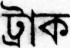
ট্রাক
